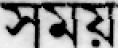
সময়
